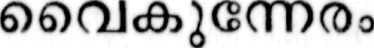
വൈകുന്നേരം
